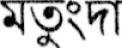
মতুংদা
